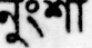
নুংশা
